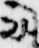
એ
